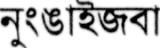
নুংঙাইজবা
